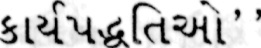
કાર્યપદ્ધતિઓ"
